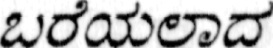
ಬರೆಯಲಾದ
